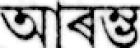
আৰম্ভ
